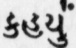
કહ્યું
